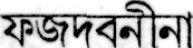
ফজদবনীনা
